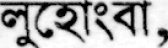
লুহোংবা,
